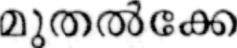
മുതല്‍ക്കേ
